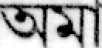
অমা
